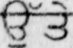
ਉੱਤੇ
